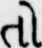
તો
